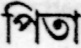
পিতা
